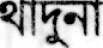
থাদুনা
